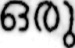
ഒരു
